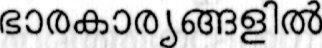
ഭാരകാര്യങ്ങളില്‍
